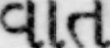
વાત
